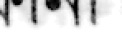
ফানা
